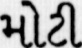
મોટી
